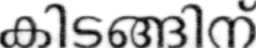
കിടങ്ങിന്
